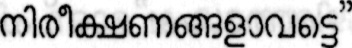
നിരീക്ഷണങ്ങളാവട്ടെ"
